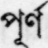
পূর্ণ
